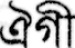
ঐগী
